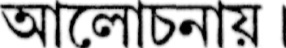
আলোচনায়।
